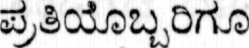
ಪ್ರತಿಯೊಬ್ಬರಿಗೂ
